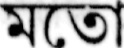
মতো
